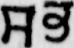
ਸਭ
